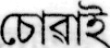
চোৱাই
